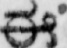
ಈ
